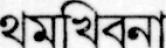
থমখিবনা
